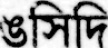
ঙসিদি
